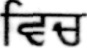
ਵਿਚ
